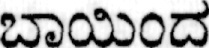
ಬಾಯಿಂದ
